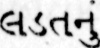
લડતનું
